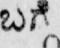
ಬಗ್ಗೆ
